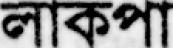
লাকপা
